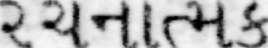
રચનાત્મક
